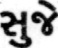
સૂજે
